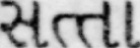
સત્તા
